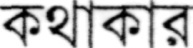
কথাকার
